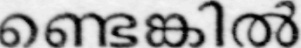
ണ്ടെങ്കില്‍
